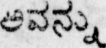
ಅವನ್ನು
